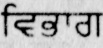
ਵਿਭਾਗ
